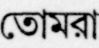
তোমরা
